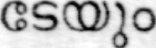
ടേയും
